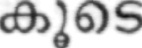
കൂടെ
